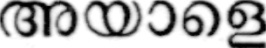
അയാളെ
